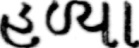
હળ્યા
